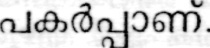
പകര്‍പ്പാണ്.
